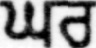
ਘਰ
